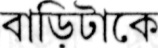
বাড়িটাকে
